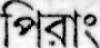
পিরাং
